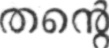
തന്റെ
